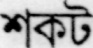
শকট
